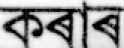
কৰাৰ
